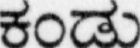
ಕಂಡು
